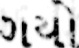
ગયો
